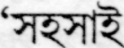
‘সহসাই
